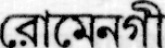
রোমেনগী
